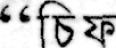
“চিফ
